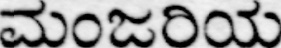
ಮಂಜರಿಯ
